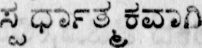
ಸ್ಪರ್ಧಾತ್ಮಕವಾಗಿ
